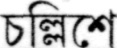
চল্লিশে
